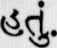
હતું.
